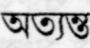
অত্যন্ত
